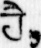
ਹੈ,
